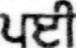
ਪਈ
